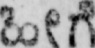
ಹೀಗೆ
